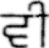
ਵੀ
